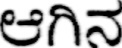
ಆಗಿನ
